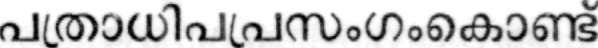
പത്രാധിപപ്രസംഗംകൊണ്ട്
